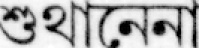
শুথানেনা
